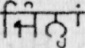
ਜਿੰਨ੍ਹਾਂ
